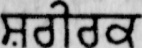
ਸ਼ਰੀਰਕ
